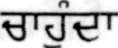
ਚਾਹੁੰਦਾ
